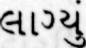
લાગ્યું
